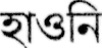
হাওনি
